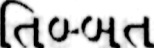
તિબ્બત
